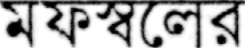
মফস্বলের
